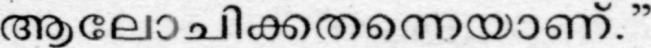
ആലോചിക്കതന്നെയാണ്."
